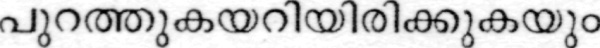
പുറത്തുകയറിയിരിക്കുകയും
